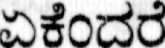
ಏಕೆಂದರೆ
